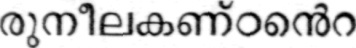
രുനീലകണ്ഠന്റെ
